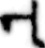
ન
